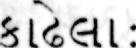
કાઢેલાઃ
